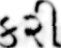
કરી
